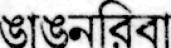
ঙাঙনরিবা
